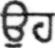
ਉਹ
